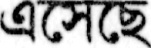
এসেছে
